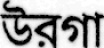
উরগা
